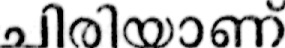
ചിരിയാണ്
